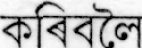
কৰিবলৈ
